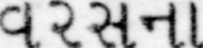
વરસના
